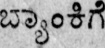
ಬ್ಯಾಂಕಿಗೆ
